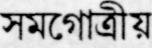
সমগোত্রীয়
